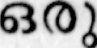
ഒരു
